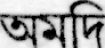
অমদি
